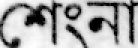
শেংনা
